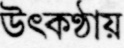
উত্কণ্ঠায়
